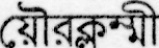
য়ৌরক্লম্মী
